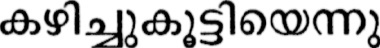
കഴിച്ചുകൂട്ടിയെന്നു
